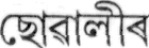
ছোৱালীৰ
